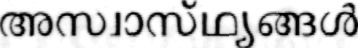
അസ്വാസ്ഥ്യങ്ങള്‍
